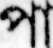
পা
